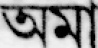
অমা
